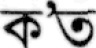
ক'ত
